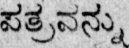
ಪತ್ರವನ್ನು
